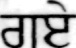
ਗਏ
